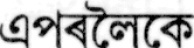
এপৰলৈকে
